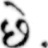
છે.
